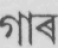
গাৰ
